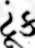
ટૂંક
